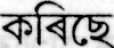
কৰিছে
